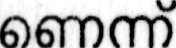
ണെന്ന്
